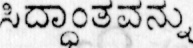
ಸಿದ್ಧಾಂತವನ್ನು
